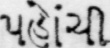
પહોંચી
